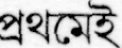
প্রথমেই
